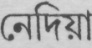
নেদিয়া
